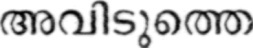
അവിടുത്തെ
